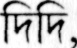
দিদি,
